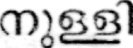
നുള്ളി
